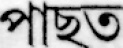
পাছত
